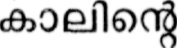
കാലിന്റെ
